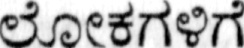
ಲೋಕಗಳಿಗೆ
